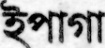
ইপাগা
